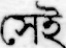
সেই
